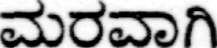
ಮರವಾಗಿ
